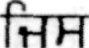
ਜਿਸ
